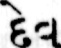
દેવ
